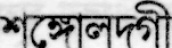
শঙ্গোলদগী
